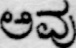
ಅವು
